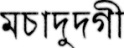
মচাদুদগী
